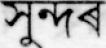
সুন্দৰ
